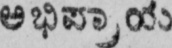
ಅಭಿಪ್ರಾಯ
